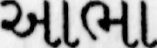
આભા
